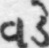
વડે
